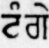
ਟੰਗੇ
